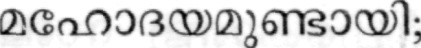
മഹോദയമുണ്ടായി;
